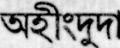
অহীংদুদা
